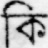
কি
